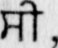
ਸੀ,
